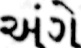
અંગે
